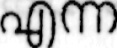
എന്ന
